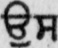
ਉਸ
